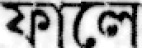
ফালে
